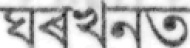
ঘৰখনত
